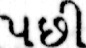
પછી
